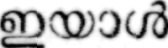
ഇയാള്‍
